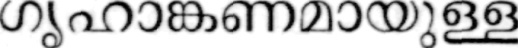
ഗൃഹാങ്കണമായുള്ള
